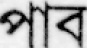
পাব
